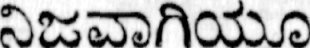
ನಿಜವಾಗಿಯೂ
